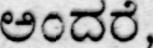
ಅಂದರೆ,
